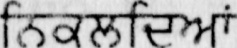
ਨਿਕਲਦਿਆਂ
